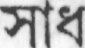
সাধ
